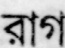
রাগ
